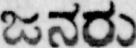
ಜನರು
